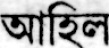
আহিল
